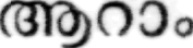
ആറാം
